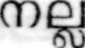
നല്ല
